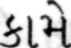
કામે
